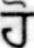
ਹੋ
